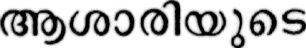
ആശാരിയുടെ
